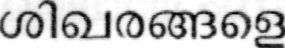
ശിഖരങ്ങളെ
